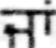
ਜਾਂ
